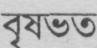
বৃষভত
